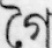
গৈ
